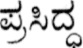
ಪ್ರಸಿದ್ಧ
